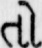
તો
